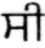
ਸੀ
